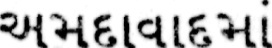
અમદાવાદમાં
